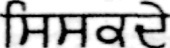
ਸਿਸਕਦੇ
